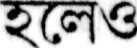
হলেও
